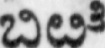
ಬಿೞೆ
